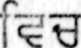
ਵਿਚ
